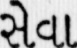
સેવા
